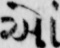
ઓં
